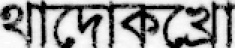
থাদোকখ্রো
